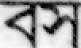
বস
